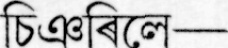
চিঞৰিলে-
